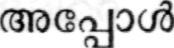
അപ്പോള്‍
